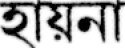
হায়না
